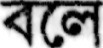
বলে
